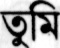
তুমি
